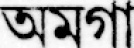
অমগা
